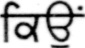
ਕਿਉਂ
